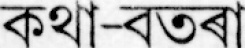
কথা-বতৰা
